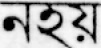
নহয়
